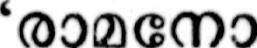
‘രാമനോ
